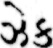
ઝેક
